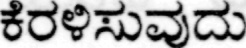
ಕೆರಳಿಸುವುದು
